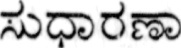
ಸುಧಾರಣಾ
